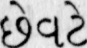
છેવટે
